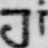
ਹਾਂ
